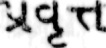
પ્રવૃત્ત
